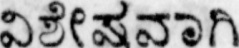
ವಿಶೇಷವಾಗಿ
